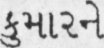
કુમારને
